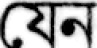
যেন
